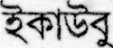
ইকাউবু
